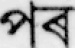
পৰ
